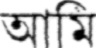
আমি
